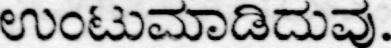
ಉಂಟುಮಾಡಿದುವು.
